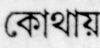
কোথায়
